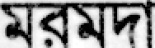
মরমদা
